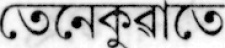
তেনেকুৱাতে
